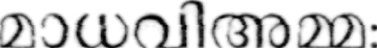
മാധവിഅമ്മ:
